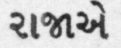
રાજાએ
